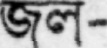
জল-
